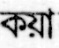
কয়া
